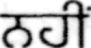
ਨਹੀਂ
